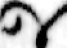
જ
